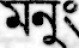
মনুং
